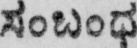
ಸಂಬಂಧ
